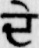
ਦੇ
